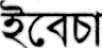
ইবেচা
